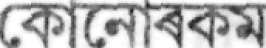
কোনোৰকম
